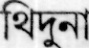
থিদুনা
